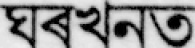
ঘৰখনত
